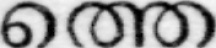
ത്തെ
